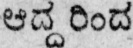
ಆದ್ದರಿಂದ
